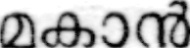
മകാന്‍
